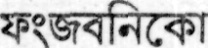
ফংজবনিকো
